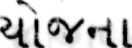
યોજના
